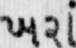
ખરાં
